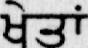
ਖੇਤਾਂ
